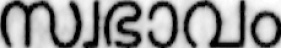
സ്വഭാവം
